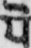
ਧੋ
